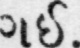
ગઈ.
